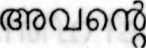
അവന്റെ
